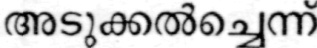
അടുക്കല്‍ച്ചെന്ന്
